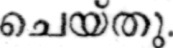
ചെയ്തു.
